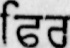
ਫਿਰ
